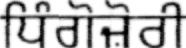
ਧਿੰਗੋਜ਼ੋਰੀ
